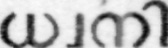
ധ്വനി
